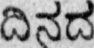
ದಿನದ
